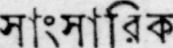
সাংসারিক
